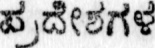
ಪ್ರದೇಶಗಳ
